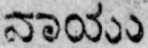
ವಾಯು
